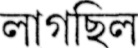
লাগছিল
